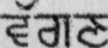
ਵੱਗਣ
